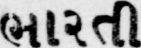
ભારતી
